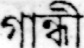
গান্ধী
